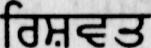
ਰਿਸ਼ਵਤ
